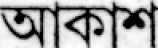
আকাশ
